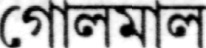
গোলমাল
